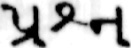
પ્રશ્ન
